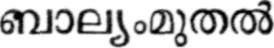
ബാല്യംമുതല്‍
